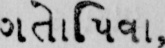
ગતોપિવા,
